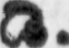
ಡಿ.
